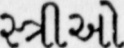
સ્ત્રીઓ
